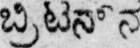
ಬ್ರಿಟನ್ನ
